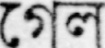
গেল
